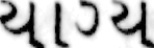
યાગ્ય
